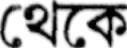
থেকে
